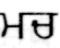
ਮਚ
